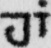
ਹਾਂ
